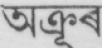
অক্রুৰ
